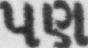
પણ
